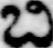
ಬಿ
